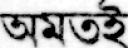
অমতই
